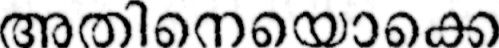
അതിനെയൊക്കെ
